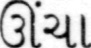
ઊંચા
